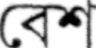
বেশ
